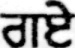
ਗਏ
